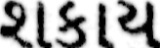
શકાય
